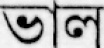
ভাল
